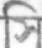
সি
